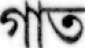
গাত
